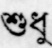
শুধু
